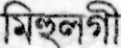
মিহুলগী
